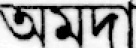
অমদা
